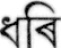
ধৰি
